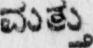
ಮತ್ತು
